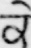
ਕੇ
